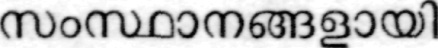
സംസ്ഥാനങ്ങളായി
